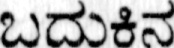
ಬದುಕಿನ
